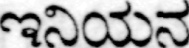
ಇನಿಯನ
